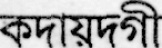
কদায়দগী
